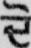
ਦੋ
